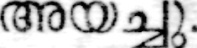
അയച്ചു.
